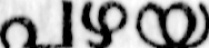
പഴയ
